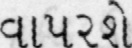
વાપરશે
